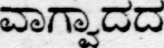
ವಾಗ್ವಾದದ
